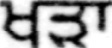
ਖੜਾ
